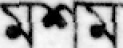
মশম
